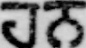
ਹਨ
